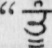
''ਤੂੰ
